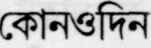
কোনওদিন
